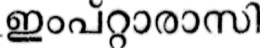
ഇംപ്റ്റാരാസി
